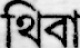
থিবা
